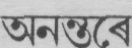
অনন্তৰে
